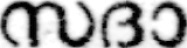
സദാ
